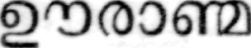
ഊരാണ്മ
